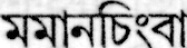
মমানচিংবা
